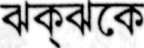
ঝক্ঝকে
